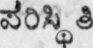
ಪರಿಸ್ಥಿತಿ
